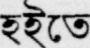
হইতে
